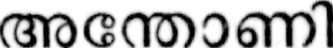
അന്തോണി
